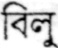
বিলু
